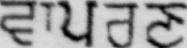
ਵਾਪਰਣ
